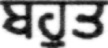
ਬਹੁਤ
